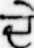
ਦੇ
